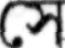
সে
